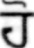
ਹੋ
